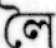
লৈ
